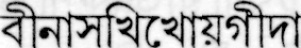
বীনাসখিখোয়গীদা
